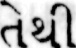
તેથી
